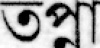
তপ্না
